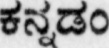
ಕನ್ನಡಂ
